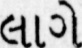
લાગે
